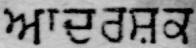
ਆਦਰਸ਼ਕ
